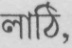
লাঠি,
